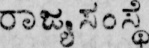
ರಾಜ್ಯಸಂಸ್ಥೆ
